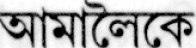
আমালৈকে
